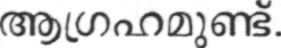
ആഗ്രഹമുണ്ട്.
